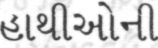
હાથીઓની
